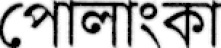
পোলাংকা
